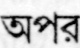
অপর
